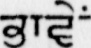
ਭਾਵੇਂ
